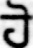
ਹੋ
